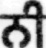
ਨੀ
